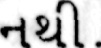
નથી.
